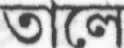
তালে
